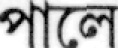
পালে
